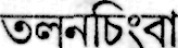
তলনচিংবা
